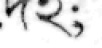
দেহ;
